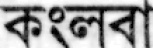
কংলবা
